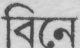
বিনে
